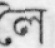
লৈ
